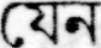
যেন
